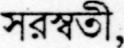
সরস্বতী,
